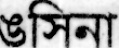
ঙসিনা
